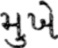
મુખે
